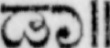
ಡಾ||
